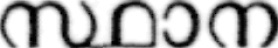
സ്ഥാന
